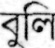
বুলি
